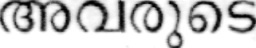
അവരുടെ
